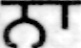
ਨਾ
